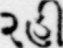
રહી
